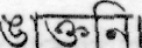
ঙাক্তনি।
